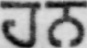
ਹਨ
